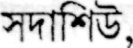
সদাশিউ,
